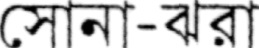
সোনা-ঝরা
